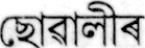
ছোৱালীৰ
